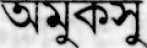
অমুকসু
